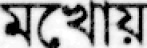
মখোয়
